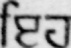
ਇਹ
